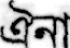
ঐনা
